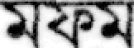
মফম
